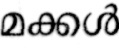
മക്കള്‍
